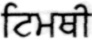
ਟਿਮਥੀ
